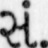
સં.
